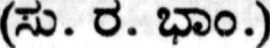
(ಸು.ರ.ಭಾ.)
